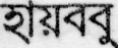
হায়ববু
